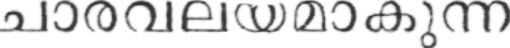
ചാരവലയമാകുന്ന
